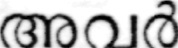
അവര്‍
